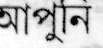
আপুনি
